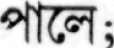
পালে;
